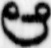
ಆ
